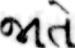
જાતે
